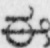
ಈ
